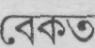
বেকত
